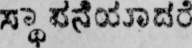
ಸ್ಥಾಪನೆಯಾದರೆ
